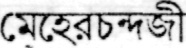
মেহেরচন্দজী
